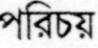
পরিচয়
